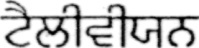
ਟੈਲੀਵੀਯਨ
